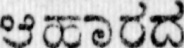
ಆಹಾರದ
